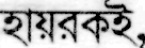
হায়রকই,
